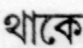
থাকে
